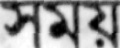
সময়
